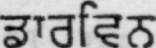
ਡਾਰਵਿਨ
